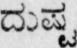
ದುಷ್ಟ
